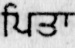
ਪਿਤਾ
